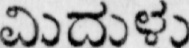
ಮಿದುಳು
